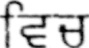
ਵਿਚ
